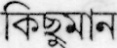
কিছুমান
